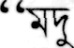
“মদু
